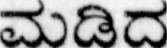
ಮಡಿದ
